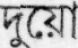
দুয়ো
